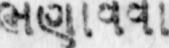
ભણાવવા
